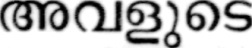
അവളുടെ
